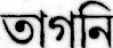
তাগনি
